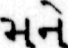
મને
